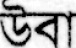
উবা
